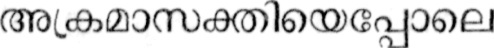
അക്രമാസക്തിയെപ്പോലെ
